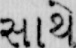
સાથે
